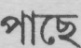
পাছে
